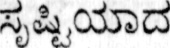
ಸೃಷ್ಟಿಯಾದ
